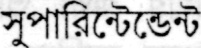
সুপারিন্টেন্ডেন্ট
